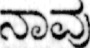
ನಾವು
